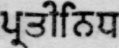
ਪ੍ਰਤੀਨਿਧ
